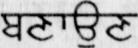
ਬਣਾਉਣ
